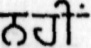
ਨਹੀਂ
